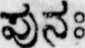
ಪುನಃ
